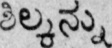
ಶಿಲ್ಕನ್ನು
